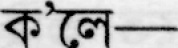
ক'লে-
